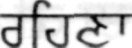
ਰਹਿਣਾ
